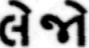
લેજો
